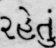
રહેતું
